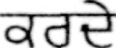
ਕਰਦੇ
